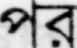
পর
